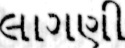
લાગણી
